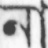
না
